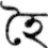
হৈ
